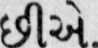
છીએ.
